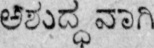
ಅಶುದ್ಧವಾಗಿ
